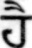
ਹੈ
